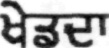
ਖੇਡਦਾ
